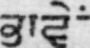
ਭਾਵੇਂ,
